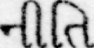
નીતિ
